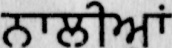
ਨਾਲੀਆਂ
